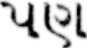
પણ
